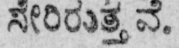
ಸೇರಿರುತ್ತವೆ.
